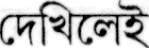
দেখিলেই
